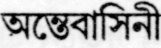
অন্তেবাসিনী
